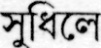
সুধিলে
